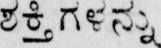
ಶಕ್ತಿಗಳನ್ನು
